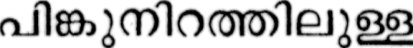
പിങ്കുനിറത്തിലുള്ള
